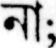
না;
